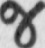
જ
